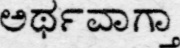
ಅರ್ಥವಾಗ್ತಾ
